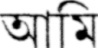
আমি
